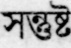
সন্তুষ্ট
